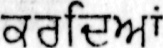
ਕਰਦਿਆਂ
